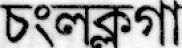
চংলক্লগা
